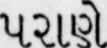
પરાણે
